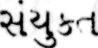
સંયુક્ત
